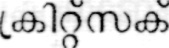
ക്രിറ്റ്സക്
